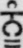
ਨੂੰ
